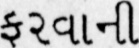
ફરવાની
